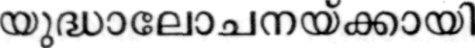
യുദ്ധാലോചനയ്ക്കായി
